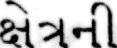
ક્ષેત્રની
